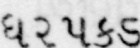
ધરપકડ
